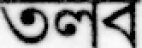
তলব
